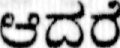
ಆದರೆ
